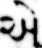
એ
